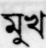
মুখ
